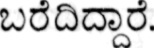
ಬರೆದಿದ್ದಾರೆ.
